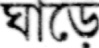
ঘাড়ে
